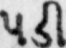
પડી
